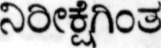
ನಿರೀಕ್ಷೆಗಿಂತ
